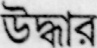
উদ্ধার
